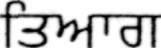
ਤਿਆਗ
